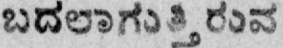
ಬದಲಾಗುತ್ತಿರುವ
